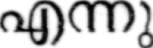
എന്നു
